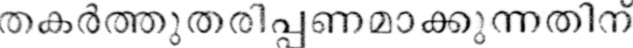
തകര്‍ത്തുതരിപ്പണമാക്കുന്നതിന്
